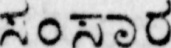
ಸಂಸಾರ
